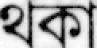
থকা
